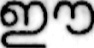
ഈ
